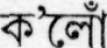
ক'লোঁ
